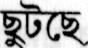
ছুটছে
